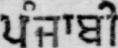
ਪੰਜਾਬੀ
